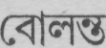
বোলন্ত
